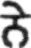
ਨੇ
